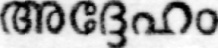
അദ്ദേഹം
